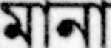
মানা
